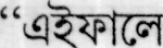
"এইফালে
